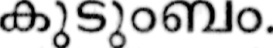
കുടുംബം.
